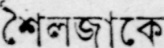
শৈলজাকে
